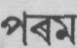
পৰম
